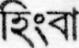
হিংবা
